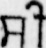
ਸੀ
